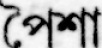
পৈশা
